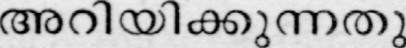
അറിയിക്കുന്നതു
